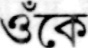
ওঁকে
